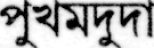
পুখমদুদা
